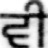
ਵੀ
